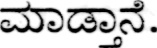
ಮಾಡ್ತಾನೆ.
